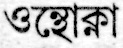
ওন্থোক্না
